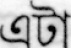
এটা
